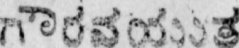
ಗೌರವಯುತ
